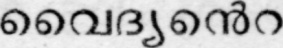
വൈദ്യന്റെ
